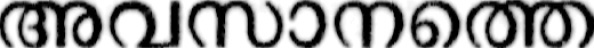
അവസാനത്തെ
